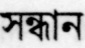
সন্ধান
